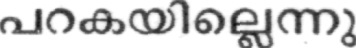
പറകയില്ലെന്നു
